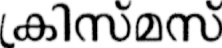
ക്രിസ്മസ്
